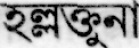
হল্লক্তুনা
